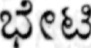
ಭೇಟಿ
